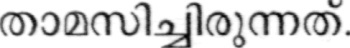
താമസിച്ചിരുന്നത്.
